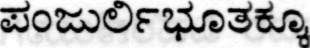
ಪಂಜುರ್ಲಿಭೂತಕ್ಕೂ
